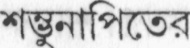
শম্ভুনাপিতের
